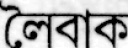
লৈবাক
